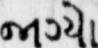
જાગ્યો
